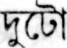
দুটো
